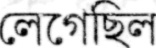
লেগেছিল
